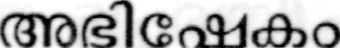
അഭിഷേകം
